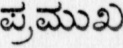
ಪ್ರಮುಖ
